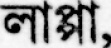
লাপ্পা,
